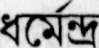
ধর্মেন্দ্র
